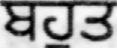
ਬਹੁਤ
